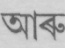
আৰু
